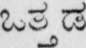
ಒತ್ತಡ
